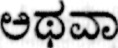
ಅಥವಾ
